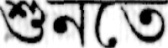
শুনতে
